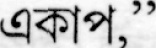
একাপ,"
